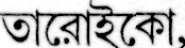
তারোইকো,
